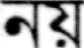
নয়
